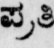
ಪ್ರತಿ
